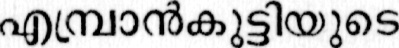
എമ്പ്രാന്‍കുട്ടിയുടെ
